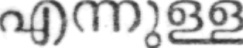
എന്നുള്ള
